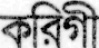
করিগী
